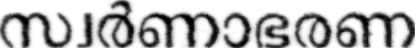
സ്വര്‍ണാഭരണ
